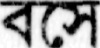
বসে
